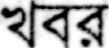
খবর
